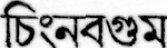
চিংনবগুম
